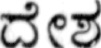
ದೇಶ
